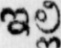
ಇಲ್ಲಿ
